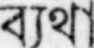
ব্যথা
